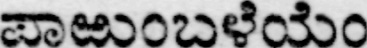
ಪಾಱುಂಬಳೆಯೆಂ
